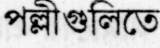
পল্লীগুলিতে
